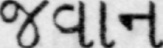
જવાન
